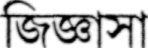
জিজ্ঞাসা
